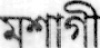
মশাগী
